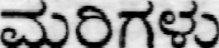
ಮರಿಗಳು
